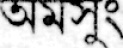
অমসুং
